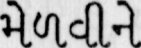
મેળવાને
